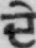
ਦੇ
